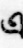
এ
